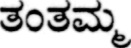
ತಂತಮ್ಮ
